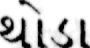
થોડા
